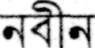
নবীন
